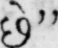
છે"
